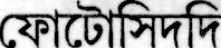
ফোটোসিদদি
